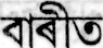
বাৰীত
